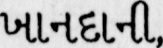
ખાનદાની,
